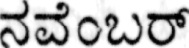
ನವೆಂಬರ್
